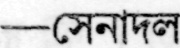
–সেনাদল
